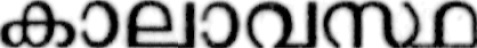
കാലാവസ്ഥ
